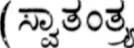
(ಸ್ವಾತಂತ್ರ್ಯ
